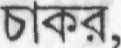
চাকর,
